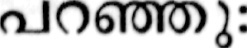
പറഞ്ഞു:
